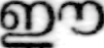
ഈ
